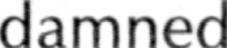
damned
